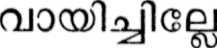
വായിച്ചില്ലേ
